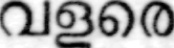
വളരെ
